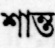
শান্ত
